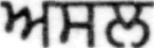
ਅਸਲ
